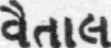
વૈતાલ
